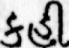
કહી
